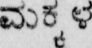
ಮಕ್ಕಳ
